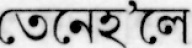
তেনেহ'লে
